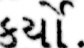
કર્યો.
